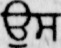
ਉਸ
